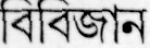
বিবিজান
